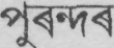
পুৰন্দৰ
